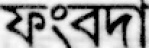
ফংবদা
